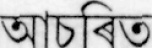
আচৰিত
